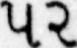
પર
